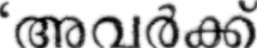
‘അവര്‍ക്ക്
